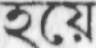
হয়ে
